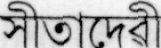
সীতাদেৱী
